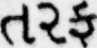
તરફ
